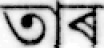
তাৰ
